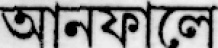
আনফালে
